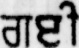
ਗਈ
